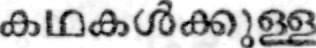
കഥകള്‍ക്കുള്ള
